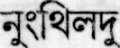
নুংথিলদু
